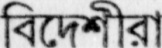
বিদেশীরা
